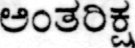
ಅಂತರಿಕ್ಷ
